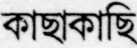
কাছাকাছি
